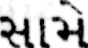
સામે
